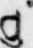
તું
